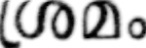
ശ്രമം
